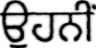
ਉਹਨੀਂ
